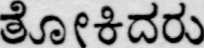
ತೋಕಿದರು
